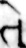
તે
